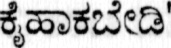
ಕೈಹಾಕಬೇಡಿ’
